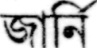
জার্নি
